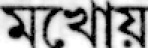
মখোয়
